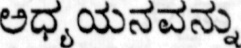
ಅಧ್ಯಯನವನ್ನು
